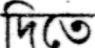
দিতে
